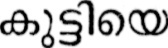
കുട്ടിയെ
